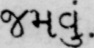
જમવું.
